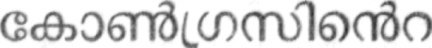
കോണ്‍ഗ്രസിന്റെ
